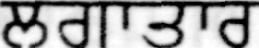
ਲਗਾਤਾਰ
